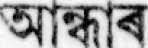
আন্ধাৰ
